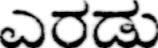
ಎರಡು
